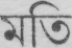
মতি
